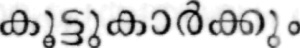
കൂട്ടുകാര്‍ക്കും
